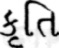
કૃતિ
